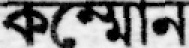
কম্মোন
